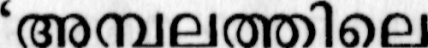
‘അമ്പലത്തിലെ
